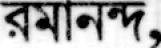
রমানন্দ,
